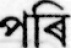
পৰি
